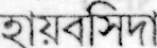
হায়বসিদা
